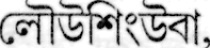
লৌউশিংউবা,
